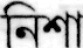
নিশা
